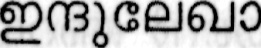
ഇന്ദുലേഖാ
